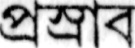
প্রস্রাব
